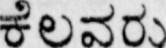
ಕೆಲವರು
